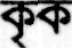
কৃক
